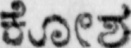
ಕೋಶ
